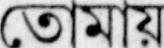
তোমায়
